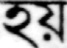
হয়
